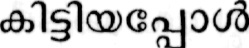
കിട്ടിയപ്പോള്‍
